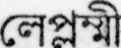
লেপ্লম্মী
